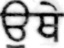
ਉਥੇ
